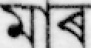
মাৰ
